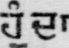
ਹੁੰਦਾ
